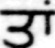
ਤਾਂ
